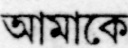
আমাকে
